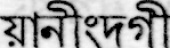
য়ানীংদগী
